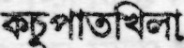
কচুপাতখিলা
